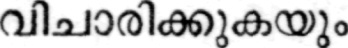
വിചാരിക്കുകയും
